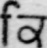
ਕਿ
